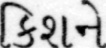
કિશને
